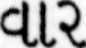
વાર
